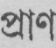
প্ৰাণ
